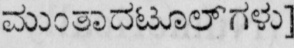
ಮುಂತಾದಟೂಲ್‌ಗಳು
